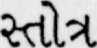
સ્તોત્ર
